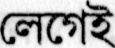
লেগেই
